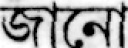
জানো
